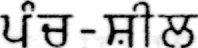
ਪੰਚ-ਸ਼ੀਲ
